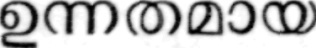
ഉന്നതമായ
